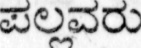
ಪಲ್ಲವರು
